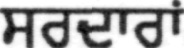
ਸਰਦਾਰਾਂ
